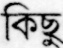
কিছু
